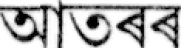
আতৰৰ
